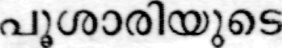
പൂശാരിയുടെ
